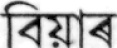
বিয়াৰ
